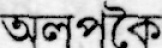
অলপকৈ
